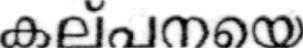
കല്പനയെ
